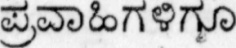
ಪ್ರವಾಹಿಗಳಿಗೂ
